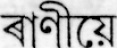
ৰাণীয়ে
